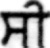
ਸੀ
